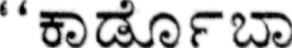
"ಕಾರ್ಡೊಬಾ
